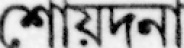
শোয়দনা
